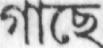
গাছে
